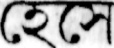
হেসে
